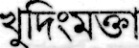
খুদিংমক্তা
